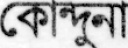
কোন্দুনা
